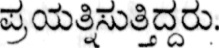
ಪ್ರಯತ್ನಿಸುತ್ತಿದ್ದರು.
